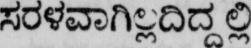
ಸರಳವಾಗಿಲ್ಲದಿದ್ದಲ್ಲಿ
